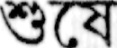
শুষে
